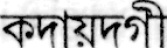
কদায়দগী
